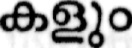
കളും
